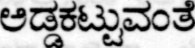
ಅಡ್ಡಕಟ್ಟುವಂತೆ
